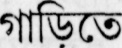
গাড়িতে
